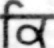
ਕਿ
